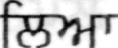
ਲਿਆ
